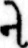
ને
